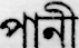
পানী
